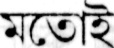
মতোই
